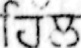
ਹਿੱਲ
